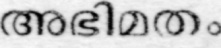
അഭിമതം
